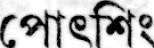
পোৎশিং
